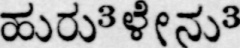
ಹುರು3ಳೇನು3
